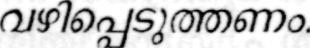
വഴിപ്പെടുത്തണം.
